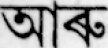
আৰু
